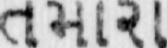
તમારા
